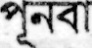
পূনবা
